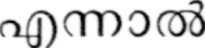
എന്നാല്‍
